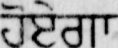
ਹੋਏਗਾ
